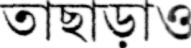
তাছাড়াও
